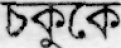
চকুকে
